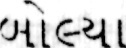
બોલ્યા
